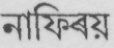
নাফিৰয়
